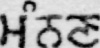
ਮੰਨਣ
